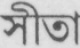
সীতা
